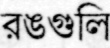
রঙগুলি
